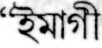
“ইমাগী
